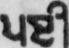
ਪਈ
